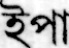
ইপা
